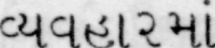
વ્યવહારમાં
